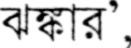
ঝঙ্কার’,
